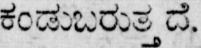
ಕಂಡುಬರುತ್ತದೆ.
